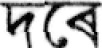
দৰে
